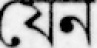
যেন
